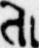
તો
